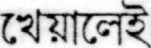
খেয়ালেই
